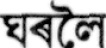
ঘৰলৈ
